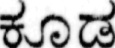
ಕೂಡ
